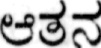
ಆತನ
